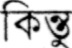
কিন্তু
